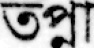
তপ্না
